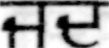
ਜਦ
